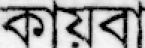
কায়বা
